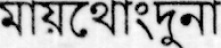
মায়থোংদুনা
